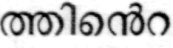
ത്തിന്റെ
